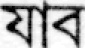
যাব
